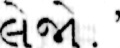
લેજો.'
